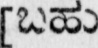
[ಬಹು
